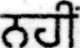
ਨਹੀਂ
